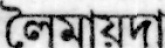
লৈমায়দা
